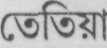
তেতিয়া
